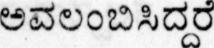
ಅವಲಂಬಿಸಿದ್ದರೆ
